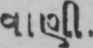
વાણી.
